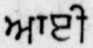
ਆਈ
